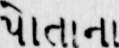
પોતાના
